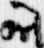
જો
